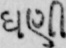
ઘણી
